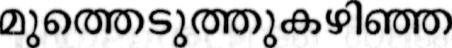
മുത്തെടുത്തുകഴിഞ്ഞ
